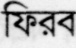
ফিরব
